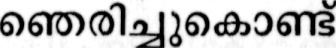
ഞെരിച്ചുകൊണ്ട്
